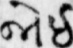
જોઈ
